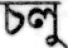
চলু
